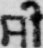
ਸੀ
